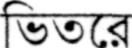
ভিতরে
